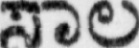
ಸಾಲ
